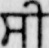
ਸੀ
